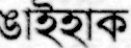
ঙাইহাক
